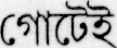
গোটেই
